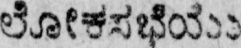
ಲೋಕಸಭೆಯು
